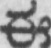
ಈ
